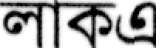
লাকএ
